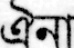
ঐনা
